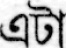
এটা
